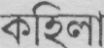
কহিলা
